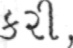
કરી,
